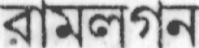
রামলগন
